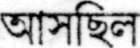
আসছিল
